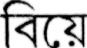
বিয়ে
